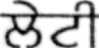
ਲੇਟੀ
